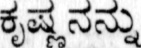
ಕೃಷ್ಣನನ್ನು
